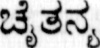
ಚೈತನ್ಯ
